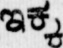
ಇಕ್ಕ
